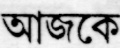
আজকে
